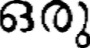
ഒരു
